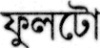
ফুলটো
